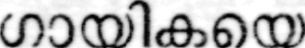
ഗായികയെ
